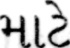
માટે
